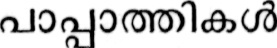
പാപ്പാത്തികള്‍
